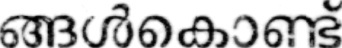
ങ്ങള്‍കൊണ്ട്
